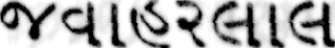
જવાહરલાલ
